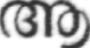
ആ
